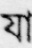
যা
